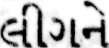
લીગને
